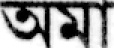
অমা
